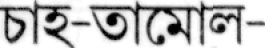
চাহ-তামোল-
